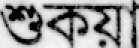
শুকয়া
